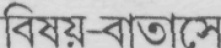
বিষয়-বাতাসে
